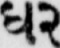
ઘર
